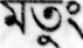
মতুং
